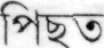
পিছত
